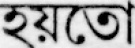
হয়তো
